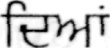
ਦਿਆਂ
